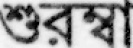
শুরম্বা
